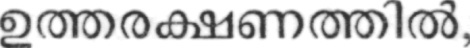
ഉത്തരക്ഷണത്തില്‍,
